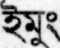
ইমুং
